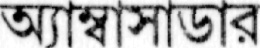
অ্যাম্বাসাডার
